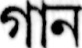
গান
